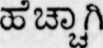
ಹೆಚ್ಚಾಗಿ
